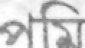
পমি
